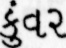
કુંવર
